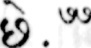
છે.૭૭
